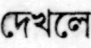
দেখলে
